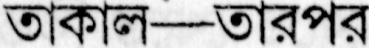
তাকাল–তারপর
